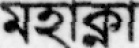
মহাক্না
